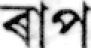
ৰাপ
